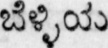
ಬೆಳ್ಳಿಯ
